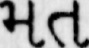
મત
